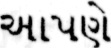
આપણે
